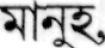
মানুহ,
